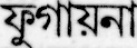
ফুগায়না
